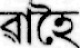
ৱাহৈ
